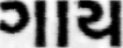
ગાય
